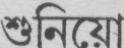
শুনিয়ো
